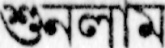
শুনলাম
